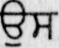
ਉਸ
